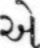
એ
